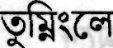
তুম্নিংলে
